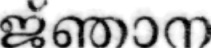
ജ്ഞാന
